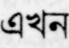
এখন
